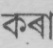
কৰা
